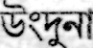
উংদুনা
